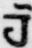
ਹੋ
